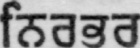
ਨਿਰਭਰ
